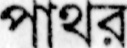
পাথর
